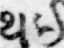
થઈ
